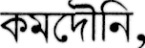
কমদৌনি,
